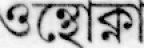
ওন্থোক্না
